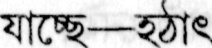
যাচ্ছে–হঠাত্
